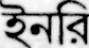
ইনরি
